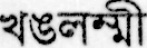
খঙম্মী
